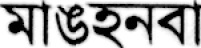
মাঙহনবা
